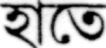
হাতে
